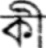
কী
